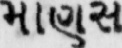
માણસ
